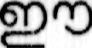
ഈ
